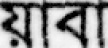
য়াবা
